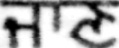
ਜਾਣ
